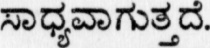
ಸಾಧ್ಯವಾಗುತ್ತದೆ.
